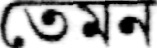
তেমন
